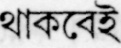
থাকবেই
